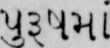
પુરૂષમાં
